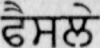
ਫੈਸਲੇ
